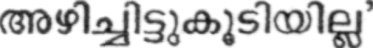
അഴിച്ചിട്ടുകൂടിയില്ല’
